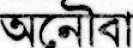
অনৌবা
